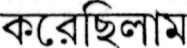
করেছিলাম
